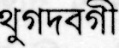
থুগদবগী
